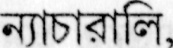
ন্যাচারালি,
